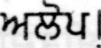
ਅਲੋਪ!
